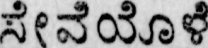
ಸೇವೆಯೊಳೆ
